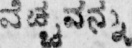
ವೆಚ್ಚವನ್ನು
